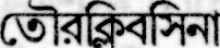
তৌরক্লিবসিনা
